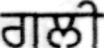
ਗਲੀ
